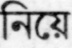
নিয়ে
